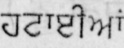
ਹਟਾਈਆਂ
